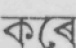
কৰে
